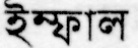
ইম্ফাল
